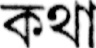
কথা
